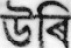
উৰি
